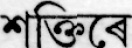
শক্তিৰে
